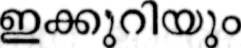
ഇക്കുറിയും
